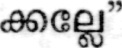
ക്കല്ലേ”
